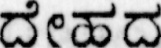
ದೇಹದ
